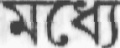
মধ্যে
